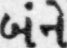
બંને
